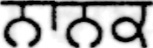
ਨਾਨਕ
